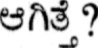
ಆಗಿತ್ತೆ?
